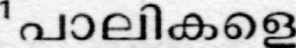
1പാലികളെ
